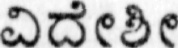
ವಿದೇಶೀ
